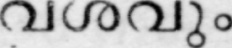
വശവും
